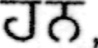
ਹਨ,
